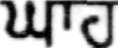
ਘਾਹ
